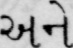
અને
